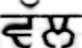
ਵੱਲ
